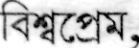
বিশ্বপ্রেম,
